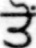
ਤੋਂ
